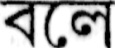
বলে
